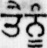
ਤੈਨੂੰ
